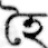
হৈ
